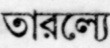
তারল্যে
